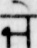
ਜੇ
